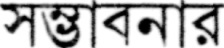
সম্ভাবনার
